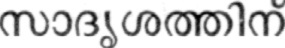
സാദൃശത്തിന്
